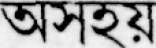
অসহয়
